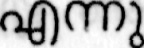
എന്നു
